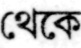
থেকে
